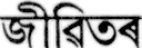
জীৱিতৰ
